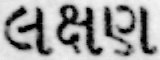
લક્ષણ
